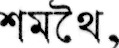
শমথৈ,
